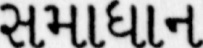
સમાધાન
